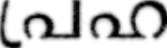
പ്രഹ
